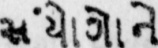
સંયોગોને
